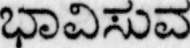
ಭಾವಿಸುವ
